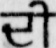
ਦੀ
